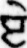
ਏ
